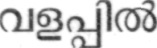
വളപ്പില്‍
